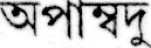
অপাম্বদু
